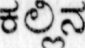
ಕಲ್ಲಿನ
